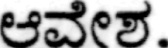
ಆವೇಶ.
